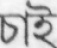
চাই
